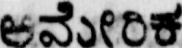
ಅಮೇರಿಕ
